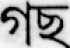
গছ
